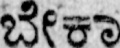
ಬೇಕಾ
